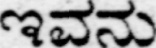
ಇವನು
